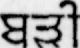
ਬੜੀ
